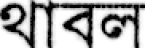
থাবল
